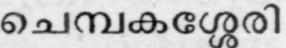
ചെമ്പകശ്ശേരി
